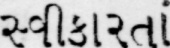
સ્વીકારતાં
